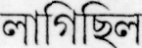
লাগিছিল
